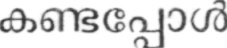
കണ്ടപ്പോള്‍
